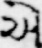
એ
